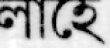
লাহে
